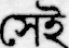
সেই
